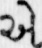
એ
